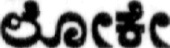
ಲೋಕೇ
